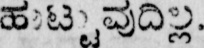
ಹುಟ್ಟುವುದಿಲ್ಲ.
